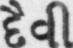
દૈવી
